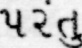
પરંતુ
